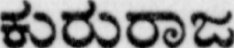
ಕುರುರಾಜ
